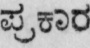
ಪ್ರಕಾರ
